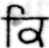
ਕਿ
